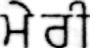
ਮੇਰੀ
